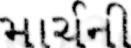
માર્ચની
